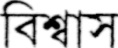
বিশ্বাস
